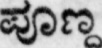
ಪೂಣ್ದ
